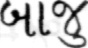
બાજુ
